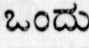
ಒಂದು
